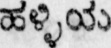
ಹಳ್ಳಿಯ
